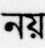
নয়
